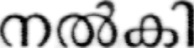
നല്‍കി
